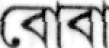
বোবা
